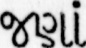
જણાં
